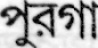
পুরগা
